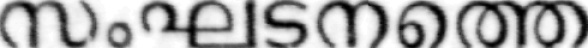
സംഘടനത്തെ
